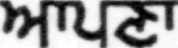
ਆਪਣਾ
